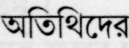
অতিথিদের
